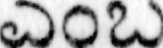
ಎಂಬ
